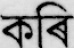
কৰি
